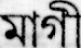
মাগী
